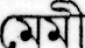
মেমী
